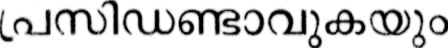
പ്രസിഡണ്ടാവുകയും
